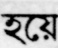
হয়ে
